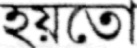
হয়তো
